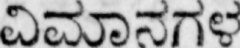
ವಿಮಾನಗಳ
